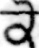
ਕੋ
